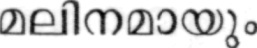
മലിനമായും
